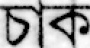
চাক
